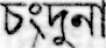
চংদুনা
